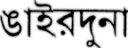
ঙাইরদুনা
